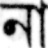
না
